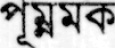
পূম্নমক
